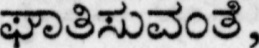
ಘಾತಿಸುವಂತೆ,
